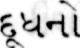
દૂધનો
